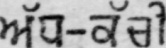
ਅੱਧ-ਕੱਚੀ
